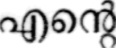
എന്റെ
